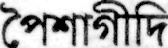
পৈশাগীদি
